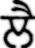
ਲੈ
